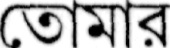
তোমার
